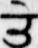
ਤੇ
